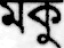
মকু
